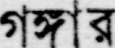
গঙ্গার
